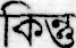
কিন্তু
